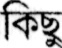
কিছু
